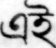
এই
